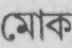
মোক
